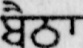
ਬੈਠਾ
